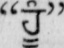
''ਹੂੰ''
